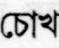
চোখ
